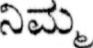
ನಿಮ್ಮ
